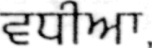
ਵਧੀਆ,
